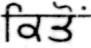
ਕਿਤੋਂ
